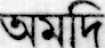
অমদি
